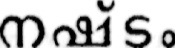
നഷ്ടം
